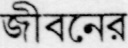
জীবনের
